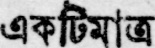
একটিমাত্র
